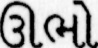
ઊભો
